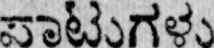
ಪಾಟುಗಳು
